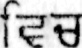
ਵਿਚ
